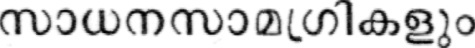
സാധനസാമഗ്രികളും
